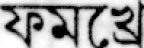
ফমখ্রে
